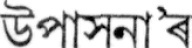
উপাসনা'ৰ
